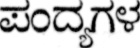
ಪಂದ್ಯಗಳ
